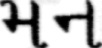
મન
